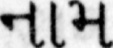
નામ
